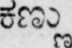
ಕಣ್ಣು
